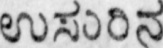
ಉಸುರಿನ
